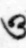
ও
